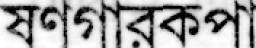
ষণগারকপা
